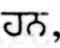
ਹਨ,
